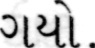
ગયો.
